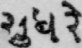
સુધરે
